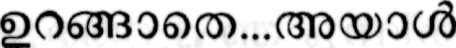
ഉറങ്ങാതെ...അയാള്‍
